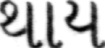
થાય
